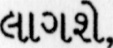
લાગશે,
